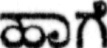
ಹಾಗೆ
